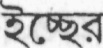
ইচ্ছের
